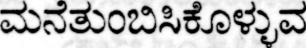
ಮನೆತುಂಬಿಸಿಕೊಳ್ಳುವ
